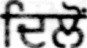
ਦਿਲੋਂ
